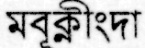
মবূক্নীংদা
